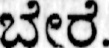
ಬೇರೆ.
